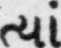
ત્યાં
